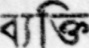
ব্যক্তি
